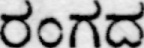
ರಂಗದ
